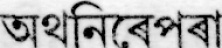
অথনিৰেপৰা
